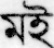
মই
